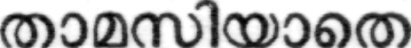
താമസിയാതെ
